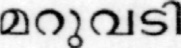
മറുവടി
